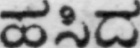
ಹಸಿದ
